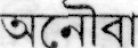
অনৌবা
